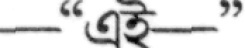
-"এই-"
